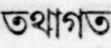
তথাগত
